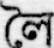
লৈ
